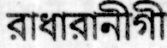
রাধারানীগী
